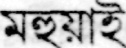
মহুয়াই
